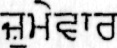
ਜ਼ੁਮੇਵਾਰ
